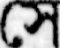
সে
